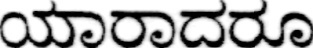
ಯಾರಾದರೂ
